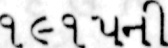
૧૯૧૫ની
